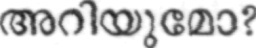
അറിയുമോ?
